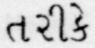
તરીકે
